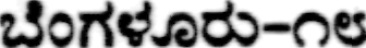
ಬೆಂಗಳೂರು-೧೮
